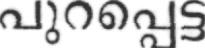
പുറപ്പെട്ട
